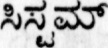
ಸಿಸ್ಟಮ್
